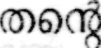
തന്റെ
